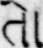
તો
